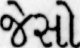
જેસો
